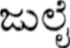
ಜುಲೈ
